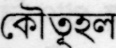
কৌতূহল
